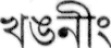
খঙনীং
